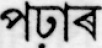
পঢ়াৰ
